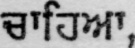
ਚਾਹਿਆ,
